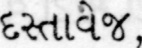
દસ્તાવેજ,
